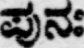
ಪುನಃ
